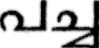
പച്ച
